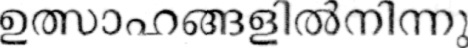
ഉത്സാഹങ്ങളില്‍നിന്നു
